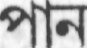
পান
